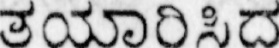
ತಯಾರಿಸಿದ
